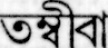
তম্বীবা
